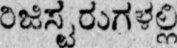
ರಿಜಿಸ್ಟರುಗಳಲ್ಲಿ
